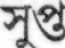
সুপ্ত
